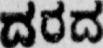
ದರದ
